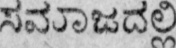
ಸಮಾಜದಲ್ಲಿ
